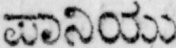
ಪಾನಿಯು
